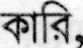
কারি,
